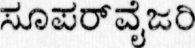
ಸೂಪರ್‌ವೈಜರಿ
